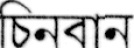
চিনবান
